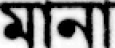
মানা
